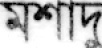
মশাদু
